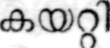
കയറ്റി
